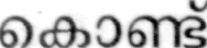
കൊണ്ട്
